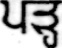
ਪੜ੍ਹ
